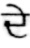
ਦੇ
